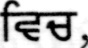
ਵਿਚ,
